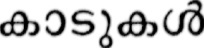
കാടുകള്‍
